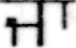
ਜਾ
